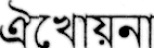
ঐখোয়না
